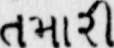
તમારી
